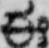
ಈ
